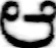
ಆ
